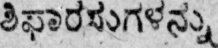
ಶಿಫಾರಸುಗಳನ್ನು
